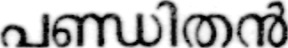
പണ്ഡിതന്‍
